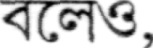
বলেও,
